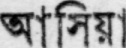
আসিয়া
